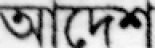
আদেশ
